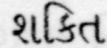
શક્તિ
